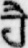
ਹੈ
